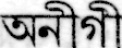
অনীগী
